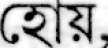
হোয়,
